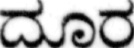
ದೂರ
